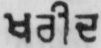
ਖਰੀਦ
